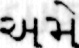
અમે
